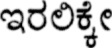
ಇರಲಿಕ್ಕೇ
